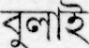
বুলাই
